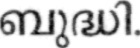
ബുദ്ധി.
